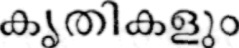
കൃതികളും
